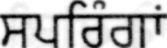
ਸਪਰਿੰਗਾਂ
